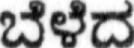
ಬೆಳೆದ
